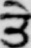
ਤੇ
